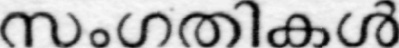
സംഗതികള്‍
